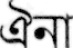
ঐনা
